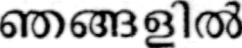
ഞങ്ങളില്‍
